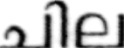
ചില
